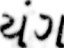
યંગ
